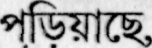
পড়িয়াছে,
